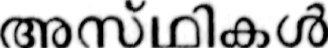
അസ്ഥികള്‍
